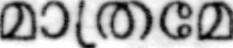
മാത്രമേ
